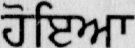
ਹੋਇਆ
